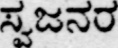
ಸ್ವಜನರ
